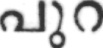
പുറ
